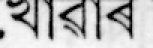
খোৱাৰ
